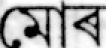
মোৰ
